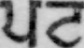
ਪਟ
